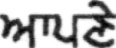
ਆਪਣੇ
